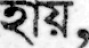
হায়,
